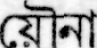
য়ৌনা
